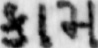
કામ
